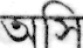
অসি
